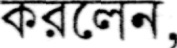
করলেন,
